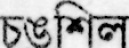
চঙশিল
